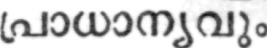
പ്രാധാന്യവും
